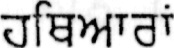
ਹਥਿਆਰਾਂ
